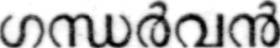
ഗന്ധര്‍വന്‍
